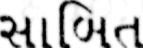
સાબિત
